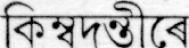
কিম্বদন্তীৰে
